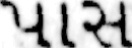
પાસ
